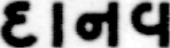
દાનવ
